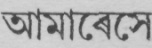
আমাৰেসে
